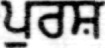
ਪੁਰਸ਼
